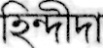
হিন্দীদা
